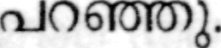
പറഞ്ഞു.
